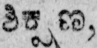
ಶಿಕ್ಷಣ,
